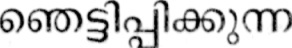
ഞെട്ടിപ്പിക്കുന്ന
